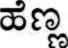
ಹೆಣ್ಣ
